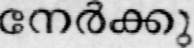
നേര്‍ക്കു
